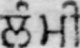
ਲੰਮੀ
